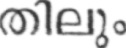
തിലും
